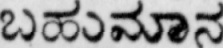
ಬಹುಮಾನ
